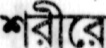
শরীরে
